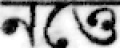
নত্তে
